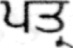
ਪਤ੍ਰ
